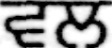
ਵਲ
